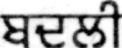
ਬਦਲੀ
